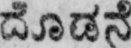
ದೊಡನೆ
